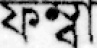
ফম্বা
